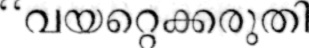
"വയറ്റെക്കരുതി
